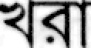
খরা
